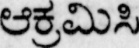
ಆಕ್ರಮಿಸಿ
